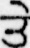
ਤੇ
